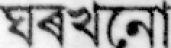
ঘৰখনো
